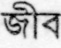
জীব
